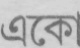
একো
